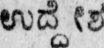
ಉದ್ದೇಶ
